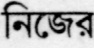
নিজের
